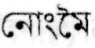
নোংমৈ
